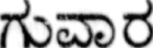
ಗುವಾರ
